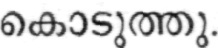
കൊടുത്തു.
